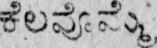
ಕೆಲವೊಮ್ಮೆ
